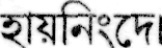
হায়নিংদে।
